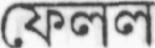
ফেলল
